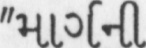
"માર્ગની
